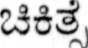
ಚಿಕಿತ್ಸೆ
